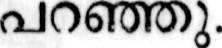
പറഞ്ഞു.
